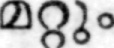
മറ്റും
